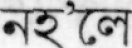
নহ'লে
